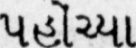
પહોંચ્યા
